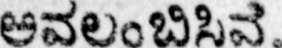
ಅವಲಂಬಿಸಿವೆ.
